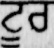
ਟੂਰ
